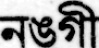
নঙগী
